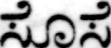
ಸೊಸೆ
